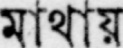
মাথায়
